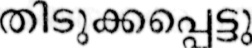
തിടുക്കപ്പെട്ടു
